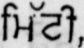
ਮਿੱਟੀ,
